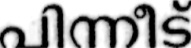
പിന്നീട്
